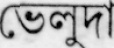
ভেলুদা
